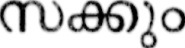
സക്കും
